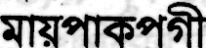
মায়পাকপগী
